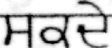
ਸਕਦੇ
